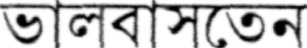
ভালবাসতেন
